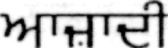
ਆਜ਼ਾਦੀ
